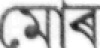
মোৰ
